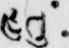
હતું.
